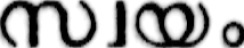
സ്വയം
